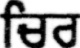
ਚਿਰ
